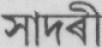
সাদৰী
